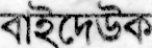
বাইদেউক
